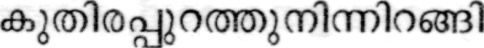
കുതിരപ്പുറത്തുനിന്നിറങ്ങി
